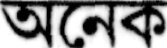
অনেক
